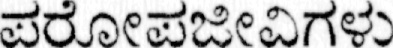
ಪರೋಪಜೀವಿಗಳು
